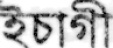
ইচাগী
